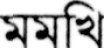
মমখি
